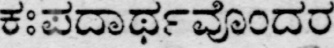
ಕಃಪದಾರ್ಥವೊಂದರ
